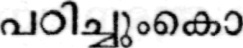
പഠിച്ചുംകൊ
